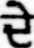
ਦੇ
